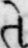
તે
